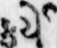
કર્યે
